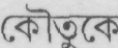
কৌতুকে
